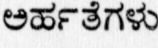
ಅರ್ಹತೆಗಳು
